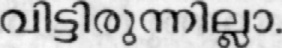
വിട്ടിരുന്നില്ലാ.
